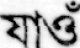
যাওঁ
